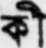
কী
